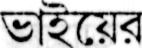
ভাইয়ের
